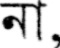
না,
